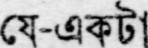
যে-একটা
